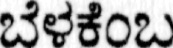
ಬೆಳಕೆಂಬ
